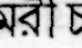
মরী
